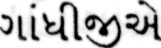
ગાંધીજીએ
